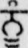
ਨੂੰ
